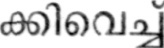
ക്കിവെച്ച്
